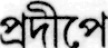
প্ৰদীপে
